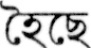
হৈছে
